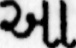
આ
